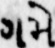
ગમે
